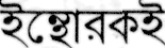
ইন্থোরকই
